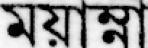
ময়াম্না
